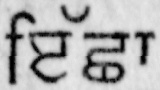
ਇੱਛਾ
